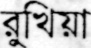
রুখিয়া
